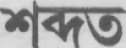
শব্দত
